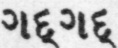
ગદ્ગદ્
